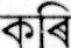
কৰি
